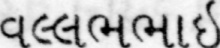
વલ્લભભાઈ
